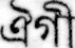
ঐগী
